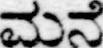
ಮನೆ
